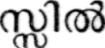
സ്സില്‍
